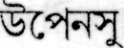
উপেনসু
